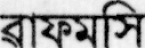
ৱাফমসি
